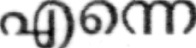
എന്നെ
